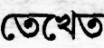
তেখেত
